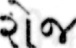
રોજ
